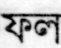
ফল
